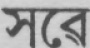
সৱে
